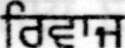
ਰਿਵਾਜ
